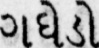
ગધેડો
